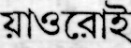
য়াওরোই
